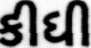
કીધી
